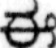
ಈ
